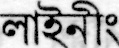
লাইনীং
